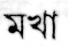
মখা
